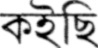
কইছি
